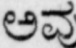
ಅವು
